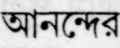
আনন্দের
